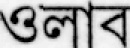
ওলাব
